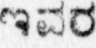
ಇವರ
